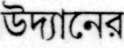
উদ্যানের
